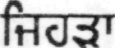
ਜਿਹੜਾ
